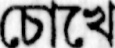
চোখে
